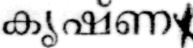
കൃഷ്ണ
